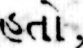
હતો,
